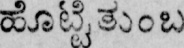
ಹೊಟ್ಟೆತುಂಬ
